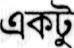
একটু
